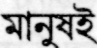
মানুষই
